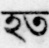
হত
